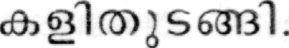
കളിതുടങ്ങി.
